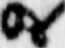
જ
